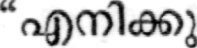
“എനിക്കു
